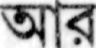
আর
